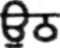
ਉਠ
